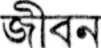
জীবন
